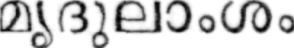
മൃദുലാംശം
